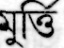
মুর্ত্তি
